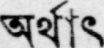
অর্থাৎ
